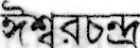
ঈশ্বরচন্দ্র
